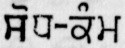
ਸੋਧ-ਕੰਮ
